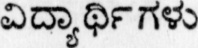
ವಿದ್ಯಾರ್ಥಿಗಳು
